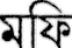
মফি
